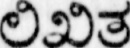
ಲಿಖಿತ
